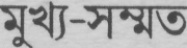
মুখ্য-সম্মত
